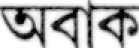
অবাক
